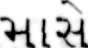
માસે
